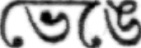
ভেঙে
